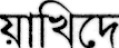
য়াখিদে
